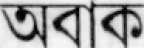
অবাক
